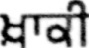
ਖ਼ਾਕੀ
